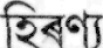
হিৰণ্য
